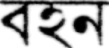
বহন
